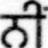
ਨੀਂ
